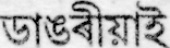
ডাঙৰীয়াই
